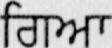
ਗਿਆ
